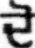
ਦੋ
